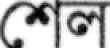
শেল
